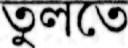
তুলতে
